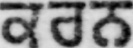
ਕਰਨ
